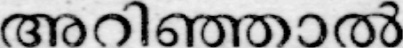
അറിഞ്ഞാല്‍
